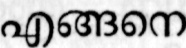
എങ്ങനെ
